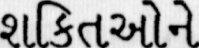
શક્તિઓને
